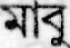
মাবু
